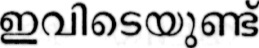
ഇവിടെയുണ്ട്
